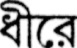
ধীরে
